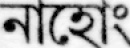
নাহোং
